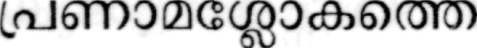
പ്രണാമശ്ലോകത്തെ
